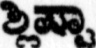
ಶ್ಲಿಷ್ಟಾ
